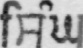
ਸਿੰਘ
